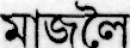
মাজলৈ
